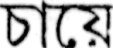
চায়ে
